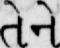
તેને
